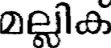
മല്ലിക്
